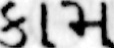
કામ
